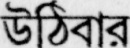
উঠিবার
